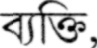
ব্যক্তি,
